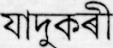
যাদুকৰী
